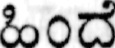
ಹಿಂದೆ
